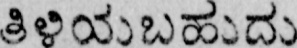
ತಿಳಿಯಬಹುದು
